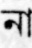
না
